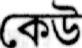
কেউ
